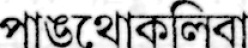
পাঙথোকলিবা
